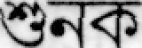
শুনক
